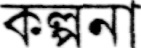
কল্পনা
